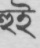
হুই
